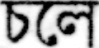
চলে
